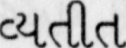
વ્યતીત
